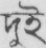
দুই
